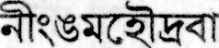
নীংঙমহৌদ্রবা
